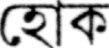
হোক
